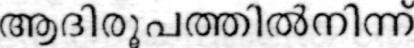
ആദിരൂപത്തില്‍നിന്ന്
